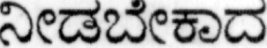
ನೀಡಬೇಕಾದ
